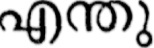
എന്തു
